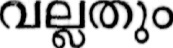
വല്ലതും
